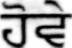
ਹੋਵੇ
